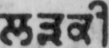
ਲੜਕੀ
